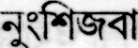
নুংশিজবা
